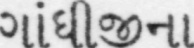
ગાંધીજીના
